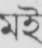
মই
